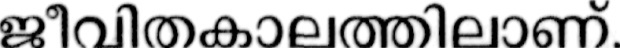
ജീവിതകാലത്തിലാണ്.
